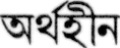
অৰ্থহীন
